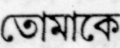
তোমাকে
